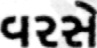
વરસે
